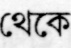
থেকে
